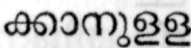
ക്കാനുള്ള
